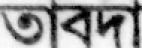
তাবদা
